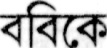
ববিকে
